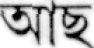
আছ
